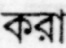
করা
